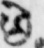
છે.
